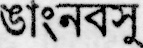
ঙাংনবসু
